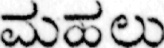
ಮಹಲು
